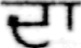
ਦਾ
